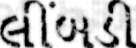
લીંબડી
